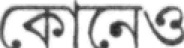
কোনেও
